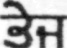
ਭੇਜ
